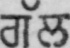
ਗੱਲ
